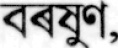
বৰষুণ,
